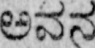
ಅವನ
